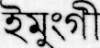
ইমুংগী
